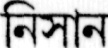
নিসান
